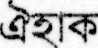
ঐহাক
